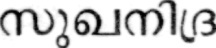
സുഖനിദ്ര
